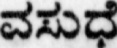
ವಸುಧೆ
